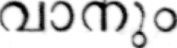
വാനും
